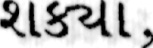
શક્યા,
